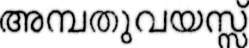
അമ്പതുവയസ്സ്
